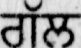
ਗੱਲ
